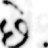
છે.
